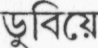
ডুবিয়ে
